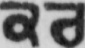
ਕਰ
